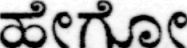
ಹೇಗೋ
